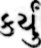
કર્યું
